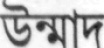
উন্মাদ
